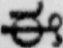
ಈ
